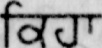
ਕਿਹਾ
